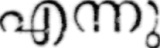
എന്നു
